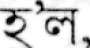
হ'ল,
